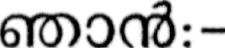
ഞാന്‍:-
